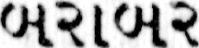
બરાબર
